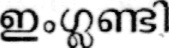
ഇംഗ്ലണ്ടി
